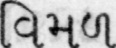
વિમળ
